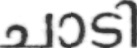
ചാടി
